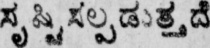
ಸೃಷ್ಟಿಸಲ್ಪಡುತ್ತದೆ
